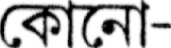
কোনো-
